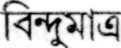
বিন্দুমাত্র
